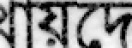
চঙদে
